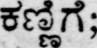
ಕಣ್ಣಿಗೆ;
